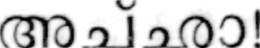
അച്ഛാ!
